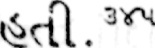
હતી.૩૪૫
